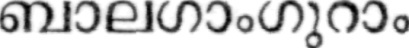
ബാലഗാംഗുറാം
